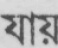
যায়
